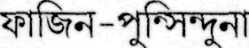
ফাজিন-পুন্সিন্দুনা
